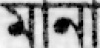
মানা
